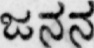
ಜನನ
